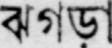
ঝগড়া
